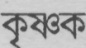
কৃষ্ণক
